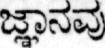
ಜ್ಞಾನವು
